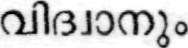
വിദ്വാനും
